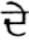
ਦੇ
